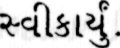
સ્વીકાર્યું.
